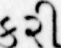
કરી
